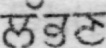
ਲੱਭਣ
